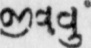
જીવવું
